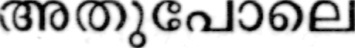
അതുപോലെ
